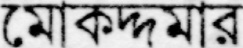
মোকদ্দমার
